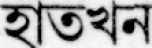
হাতখন
